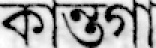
কান্তগা
